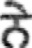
ਨੇ
